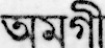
অমগী
